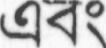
এবং
